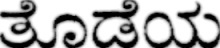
ತೊಡೆಯ
